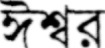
ঈশ্বর
